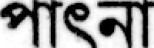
পাৎনা
